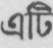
এটি
